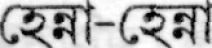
হেন্না-হেন্না
